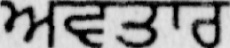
ਅਵਤਾਰ
